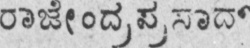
ರಾಜೇಂದ್ರಪ್ರಸಾದ್
